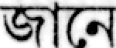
জানে
